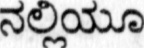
ನಲ್ಲಿಯೂ
